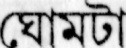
ঘোমটা
